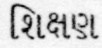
શિક્ષણ
